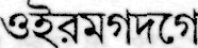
ওইরমগদগে
